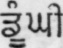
ਡੂੰਘੀ
